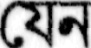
যেন
